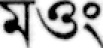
মওং
